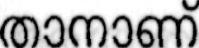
താനാണ്
